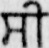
ਸੀ
